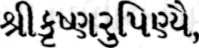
શ્રીકૃષ્ણરુપિણ્યૈ,
